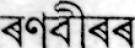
ৰণবীৰৰ
